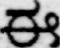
ಈ
